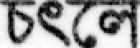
চৎলে
